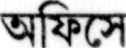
অফিসে
